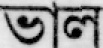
ভাল
